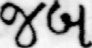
જબ
